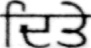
ਦਿਤੇ
